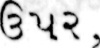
ઉપર,
